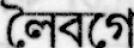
লৈবগে
